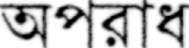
অপরাধ
